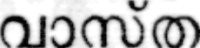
വാസ്ത
